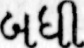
બધી
